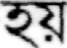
হয়
